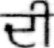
ਦੀ
